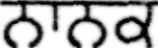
ਨਾਨਕ
